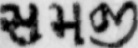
સમજી
